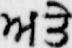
ਅਤੇ
